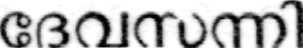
ദേവസന്നി
